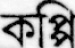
কপ্পি
